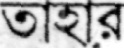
তাহার
